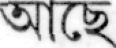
আছে
